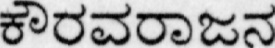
ಕೌರವರಾಜನ
